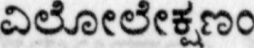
ವಿಲೋಲೇಕ್ಷಣಂ
